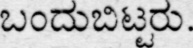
ಬಂದುಬಿಟ್ಟರು.
